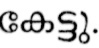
കേട്ടു.
